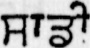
ਸਾਡੀ
